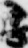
કે
